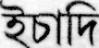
ইচাদি
